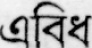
এবিধ
